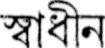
স্বাধীন
